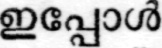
ഇപ്പോള്‍
